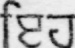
ਇਹ
